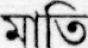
মাতি
